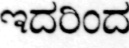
ಇದರಿಂದ
